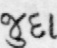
જુદા
